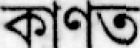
কাণত
